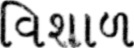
વિશાળ
